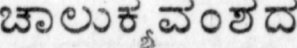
ಚಾಲುಕ್ಯವಂಶದ
